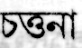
চত্তনা
